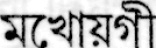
মখোয়গী
